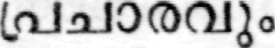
പ്രചാരവും
